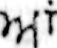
ਆਂ
